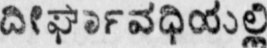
ದೀರ್ಘಾವಧಿಯಲ್ಲಿ
